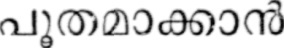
പൂതമാക്കാന്‍
